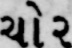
ચોર
